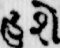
હશે
